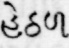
હેઠળ
